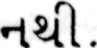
નથી.
